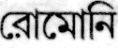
রোমোনি
